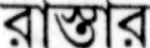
রাস্তার
